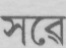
সৱে
